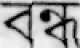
বন্ধ
